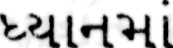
ધ્યાનમાં
